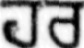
ਹਰ
